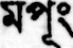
মপূং
